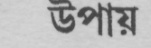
উপায়
